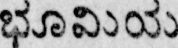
ಭೂಮಿಯ
